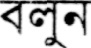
বলুন
